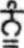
ਨੂੰ
